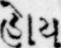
હોય
